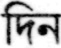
দিন
